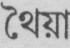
থৈয়া
